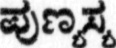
ಪುಣ್ಯಸ್ಯ
